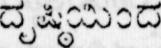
ದೃಷ್ಠಿಯಿಂದ
